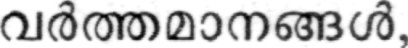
വര്‍ത്തമാനങ്ങള്‍,
